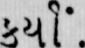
પણ
